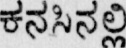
ಕನಸಿನಲ್ಲಿ
